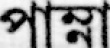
পাম্না
